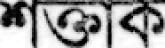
শক্তাক
